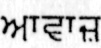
ਆਵਾਜ਼
